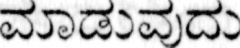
ಮಾಡುವುದು
